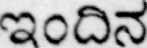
ಇಂದಿನ
